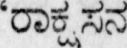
‘ರಾಕ್ಷಸನ
